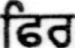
ਫਿਰ
